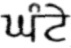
ਘੰਟੇ
